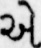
એ
